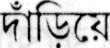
দাঁড়িয়ে
